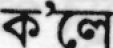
ক'লে
